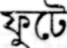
ফুটে
